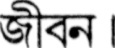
জীবন।
